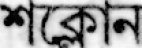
শক্লোন
